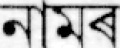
নামৰ
